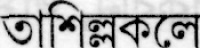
তাশিল্লকলে
